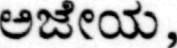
ಅಜೇಯ,
